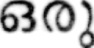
ഒരു
